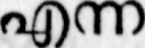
എന്ന
